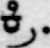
ಕ್ರಿ.
